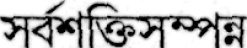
সর্বশক্তিসম্পন্ন
